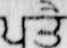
ਪਤੈ
